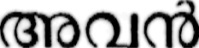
അവന്‍
